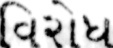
વિરોધ
